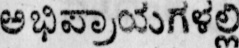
ಅಭಿಪ್ರಾಯಗಳಲ್ಲಿ
